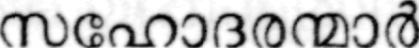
സഹോദരന്മാര്‍
